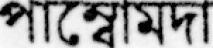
পাম্বোমদা
